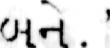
બને.'
